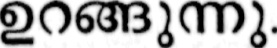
ഉറങ്ങുന്നു.
